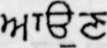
ਆਉਣ
